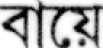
বায়ে
